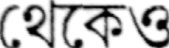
থেকেও
